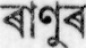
ৰাণুৰ
